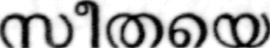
സീതയെ
